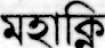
মহাক্নি
